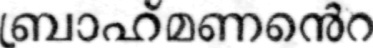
ബ്രാഹ്മണന്റെ
